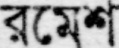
রমেশ
